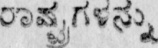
ರಾಷ್ಟ್ರಗಳನ್ನು
